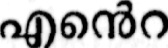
എന്റെ
